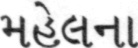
મહેલના
